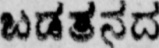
ಬಡತನದ
